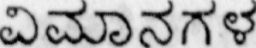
ವಿಮಾನಗಳ
